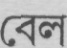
বেল
